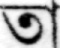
তা
